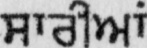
ਸਾਰੀਆਂ
